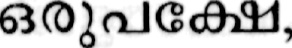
ഒരുപക്ഷേ,
